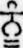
ਨੂੰ
